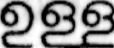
ഉള്ള
